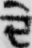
ਦੇ
